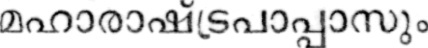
മഹാരാഷ്ട്രപാപ്പാസും
